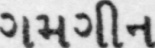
ગમગીન
